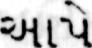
આપે
